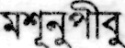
মশূনুপীবু
